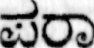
ಪರಾ
